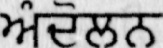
ਅੰਦੋਲਨ
